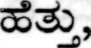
ಹೆತ್ತು,
